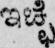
ಇಚ್ಛೆ
